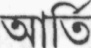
আর্তি
